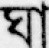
ঘা
